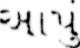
આપું
